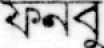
ফনবু
